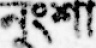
নুংশা
